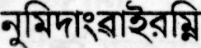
নুমিদাংৱাইরম্নি
